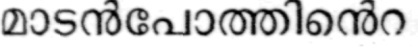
മാടന്‍പോത്തിന്റെ
